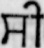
ਸੀ
